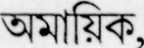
অমায়িক,
